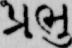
પ્રભુ
